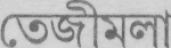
তেজীমলা
